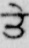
ਤੇ
